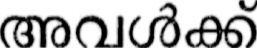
അവള്‍ക്ക്
